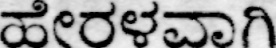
ಹೇರಳವಾಗಿ
